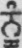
ਨੂੰ
